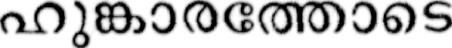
ഹുങ്കാരത്തോടെ
